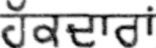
ਹੱਕਦਾਰਾਂ
